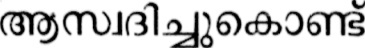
ആസ്വദിച്ചുകൊണ്ട്
